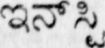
ಇನ್‌ಸ್ಟಿ
